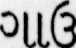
ગાઉ
